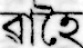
ৱাহৈ
